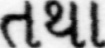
તથા
